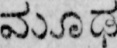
ಮೂಢ
